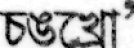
চঙখ্রো’
